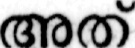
അത്
